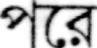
পরে
